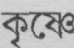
কৃষ্ণে
